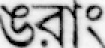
ঙরাং
